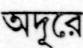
অদূরে
